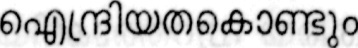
ഐന്ദ്രിയതകൊണ്ടും
